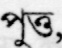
পুত্ত,
